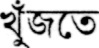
খুঁজতে
